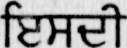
ਇਸਦੀ
